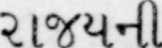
રાજ્યની
